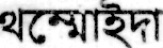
থম্মোইদা
